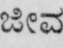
ಜೀವ
